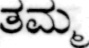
ತಮ್ಮ
